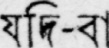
যদি-বা
